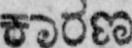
ಕಾರಣ
